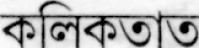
কলিকতাত
